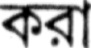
করা
